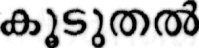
കൂടുതല്‍
